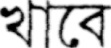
খাবে
